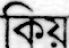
কিয়
